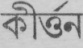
কীৰ্ত্তন
